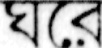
ঘরে
